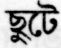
ছুটে
